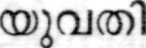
യുവതി
